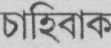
চাহিবাক
